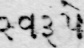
સ્વરૂપે
